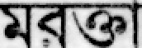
মরক্তা
